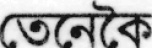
তেনেকৈ
